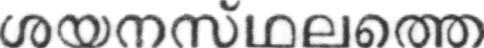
ശയനസ്ഥലത്തെ
